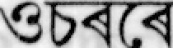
ওচৰৰে
